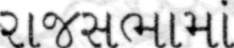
રાજસભામાં
